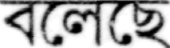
বলেছে
